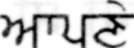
ਆਪਣੇ
